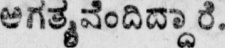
ಅಗತ್ಯವೆಂದಿದ್ದಾರೆ.
